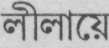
লীলায়ে
